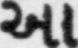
આ
